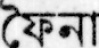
ফৈনা
